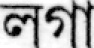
লগা
